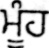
ਮੂੰਹ
